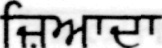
ਜ਼ਿਆਦਾ
